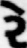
રે
